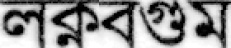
লক্নবগুম
